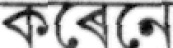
কৰেনে
